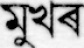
মুখৰ
